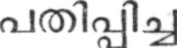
പതിപ്പിച്ച
